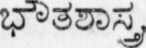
ಭೌತಶಾಸ್ತ್ರ,
